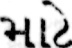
માટે
